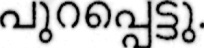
പുറപ്പെട്ടു.
